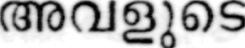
അവളുടെ
